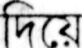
দিয়ে
